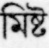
মিষ্ট
